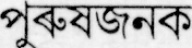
পুৰুষজনক
